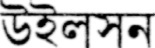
উইলসন
